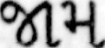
જામ
